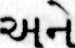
અને
